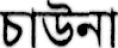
চাউনা
